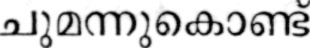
ചുമന്നുകൊണ്ട്
